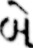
બે
